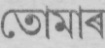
তোমাৰ
